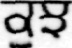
ਕੁਝ
